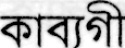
কাব্যগী
